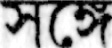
সঙ্গে
